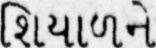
શિયાળને
